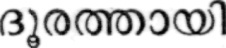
ദൂരത്തായി
